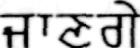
ਜਾਣਗੇ
